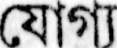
যোগ্য
